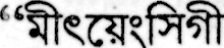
“মীৎয়েংসিগী
